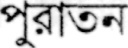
পুরাতন
